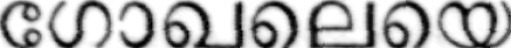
ഗോഖലെയെ
